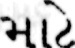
માટે
